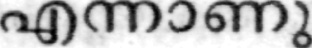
എന്നാണു
